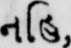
નહિ,
